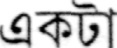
একটা
